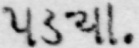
પડ્યા.
